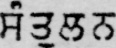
ਸੰਤੁਲਨ
